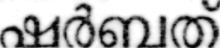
ഷര്‍ബത്
